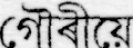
গৌৰীয়ে
